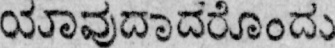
ಯಾವುದಾದರೊಂದು
